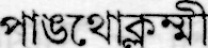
পাঙথোক্লম্মী
